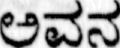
ಅವನ
